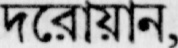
দরোয়ান,
